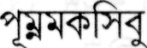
পূম্নমকসিবু
